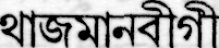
থাজমানবীগী
